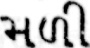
મળી
